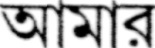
আমার
